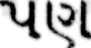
પણ
